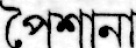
পৈশানা
